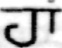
ਹਾਂ
